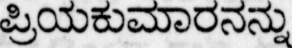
ಪ್ರಿಯಕುಮಾರನನ್ನು
